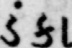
ડંકા
